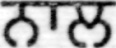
ਨਾਲ
